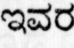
ಇವರ
